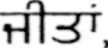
ਜੀਤਾਂ,
